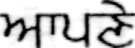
ਆਪਣੇ
